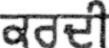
ਕਰਦੀ
